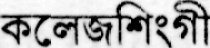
কলেজশিংগী
